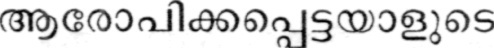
ആരോപിക്കപ്പെട്ടയാളുടെ
